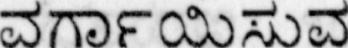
ವರ್ಗಾಯಿಸುವ
